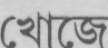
খোজে
